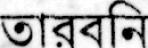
তারবনি
